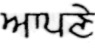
ਆਪਣੇ
